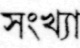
সংখ্যা
